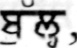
ਬੁੱਲ੍ਹ,
